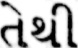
તેથી
